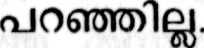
പറഞ്ഞില്ല.
